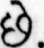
છે.
